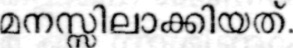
മനസ്സിലാക്കിയത്.
